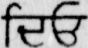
ਦਿਓ
